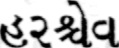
હરશ્ર્ચેવ
